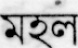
মহল
